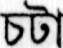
চটা
